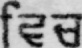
ਵਿਚ
